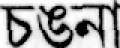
চঙনা
